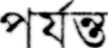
পর্যন্ত
